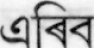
এৰিৰ
